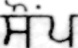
ਸੌਂਪ
